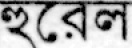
হুরেল
